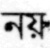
নয়
